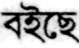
বইছে
